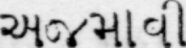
અજમાવી
